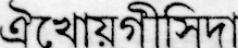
ঐখোয়গীসিদা
